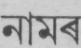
নামৰ
